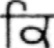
ਕਿ
